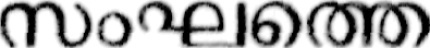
സംഘത്തെ
